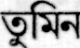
তুমিন
